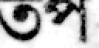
তপ
